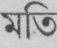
মতি
